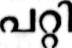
പറ്റി
